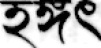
হঙ্গৎ
